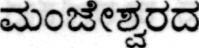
ಮಂಜೇಶ್ವರದ
